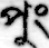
পুং
